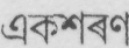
একশৰণ
